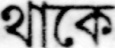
থাকে
